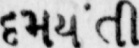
દમયંતી
